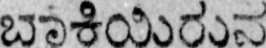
ಬಾಕಿಯಿರುವ
